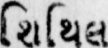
શિથિલ
